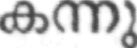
കന്നു
